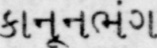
કાનૂનભંગ
